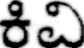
ಕಿವಿ
